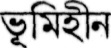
ভূমিহীন
